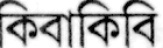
কিবাকিবি
